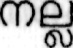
നല്ല
